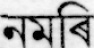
নমৰি
